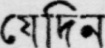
যেদিন
